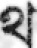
থ
